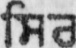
ਸਿਰ
